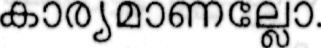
കാര്യമാണല്ലോ.
